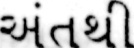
અંતથી
